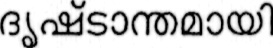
ദൃഷ്ടാന്തമായി
